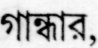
গান্ধার,
